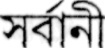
সর্বানী
